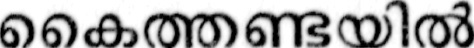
കൈത്തണ്ടയില്‍
